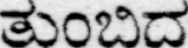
ತುಂಬಿದ
